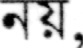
নয়,
